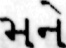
મને
